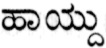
ಹಾಯ್ದು
